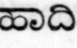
ಹಾದಿ
